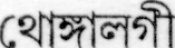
থোঙ্গালগী
